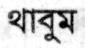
থাবুম
